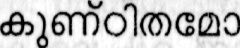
കുണ്ഠിതമോ
